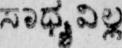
ಸಾಧ್ಯವಿಲ್ಲ
